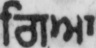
ਗਿਆ
